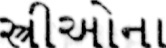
સ્ત્રીઓના
